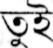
তুই
